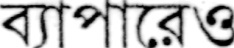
ব্যাপারেও
